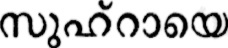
സുഹ്റായെ
